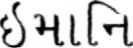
ઈમાનિ
